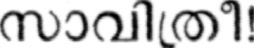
സാവിത്രീ!
